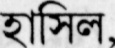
হাসিল,
